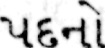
પદનો
